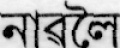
নাৱলৈ
